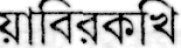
য়াবিরকখি
